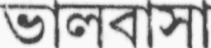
ভালবাসা
